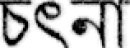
চৎনা
